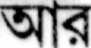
আর
